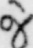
જે
